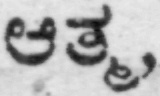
ಆತ್ಮ,
